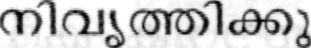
നിവൃത്തിക്കു
